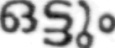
ഒട്ടും
